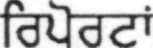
ਰਿਪੋਰਟਾਂ
